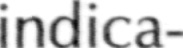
indica-
